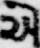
એ
